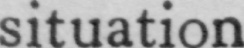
situation
